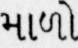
માળો
